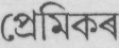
প্রেমিকৰ
